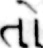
તો
